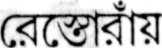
রেস্তোরাঁয়
